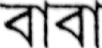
বাবা
